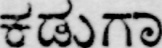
ಕಡುಗಾ
